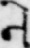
ને
